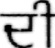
ਦੀ
